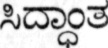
ಸಿದ್ಧಾಂತ
